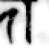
দা
